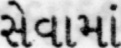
સેવામાં
